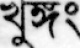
খুঙ্গং
